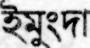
ইমুংদা
